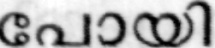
പോയി
